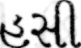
હસી
